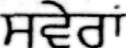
ਸਵੇਰਾਂ
